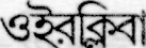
ওইরক্লিবা
